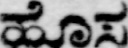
ಹೊಸ
